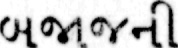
બજાજની
